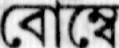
বোম্বে
